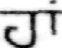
ਹਾਂ
